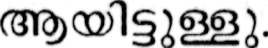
ആയിട്ടുള്ളു.
